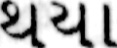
થયા
